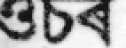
ওচৰ
